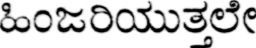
ಹಿಂಜರಿಯುತ್ತಲೇ
